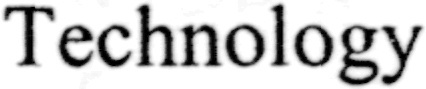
Technology
